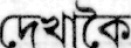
দেখাকৈ
